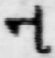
ન
